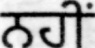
ਨਹੀਂ
